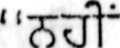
''ਨਹੀਂ
